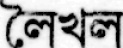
লৈখল
